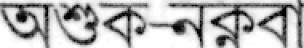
অশুক-নক্নবা
